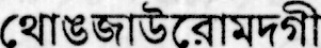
থোঙজাউরোমদগী
